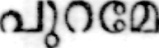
പുറമേ
